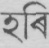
হৰি
